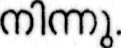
നിന്നു.
